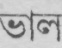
ভাল
